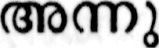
അന്നു
